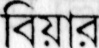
বিয়ার
